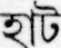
হাট
